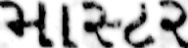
માસ્ટર
